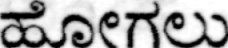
ಹೋಗಲು
